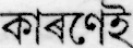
কাৰণেই
